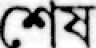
শেষ
